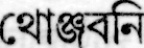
থোঞ্জবনি
